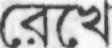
রেখে
